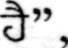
ਹੈ'',
